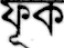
ফূক
